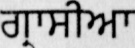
ਗ੍ਰਾਸੀਆ
